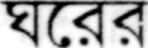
ঘরের
